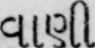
વાણી
